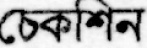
চেকশিন
